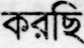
করছি
